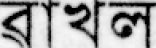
ৱাখল
